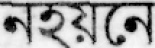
নহয়নে
